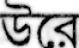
উরে
